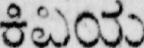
ಕಿವಿಯ
